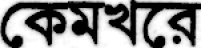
কেমখরে
